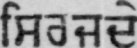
ਸਿਰਜਦੇ
